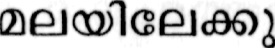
മലയിലേക്കു
